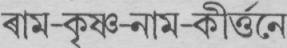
ৰাম-কৃষ্ণ-নাম-কীৰ্ত্তনে
